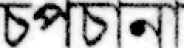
চপচানা
